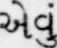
એવું
